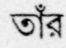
তাঁর
